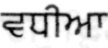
ਵਧੀਆ
